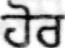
ਹੋਰ
